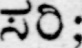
ಸರಿ;
